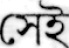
সেই
